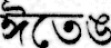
ঈতেঙ
